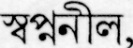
স্বপ্ননীল,
